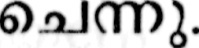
ചെന്നു.
